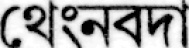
থেংনবদা
